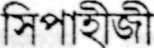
সিপাহীজী
